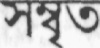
সম্বৃত
